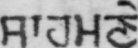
ਸਾਹਮਣੇ
